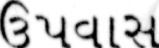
ઉપવાસ
